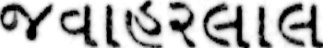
જવાહરલાલ
